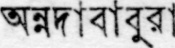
অন্নদাবাবুরা
